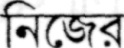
নিজের
